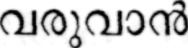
വരുവാന്‍
